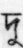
দু
